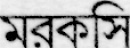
মরকসি
